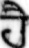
ਹੈ
